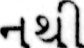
નથી
